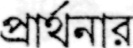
প্রার্থনার
